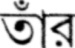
তাঁর
